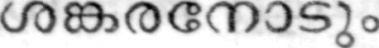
ശങ്കരനോടും
